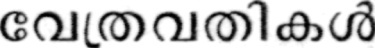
വേത്രവതികള്‍
